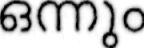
ഒന്നും
